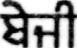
ਬੇਜੀ
